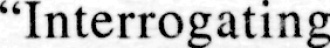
“Interrogating
